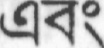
এবং
